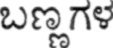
ಬಣ್ಣಗಳ
